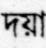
দয়া
